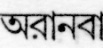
অরানবা
